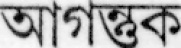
আগন্তুক
